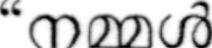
“നമ്മള്‍
